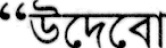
“উদেবো
